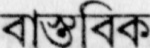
বাস্তবিক
